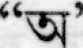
"অ'
